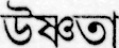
উষ্ণতা
